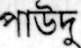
পাউদু
